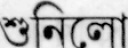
শুনিলো
